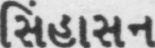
સિંહાસન
